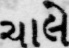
ચાલે
